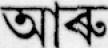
আৰু
